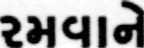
રમવાને
